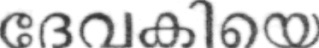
ദേവകിയെ
